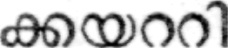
ക്കയററി
